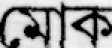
মোক
